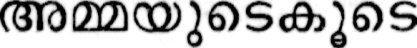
അമ്മയുടെകൂടെ
